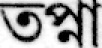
তপ্না
